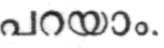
പറയാം.
